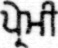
ਪ੍ਰੇਮੀ
